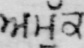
ਅਮੁੱਕ
